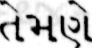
તેમણે
